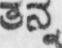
ತನ್ನ
